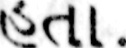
હતા.
